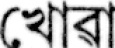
খোৱা
